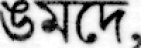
ঙমদে,
